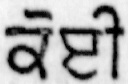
ਕੋਈ
